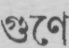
গুণে
